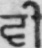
ਵੀ
